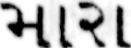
મારા
